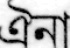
ঐনা
